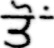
ਤੋਂ
